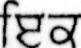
ਇਕ
